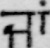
ਜਾਂ
